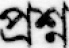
প্রশ্ন
